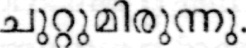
ചുറ്റുമിരുന്നു.
